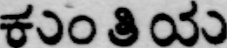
ಕುಂತಿಯ
